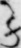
કે
